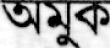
অমুক
